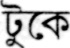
টুকে
